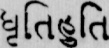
ધૃતિહુતિ
